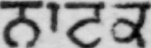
ਨਾਟਕ
